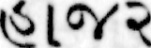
હાજર
